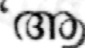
'ആ
